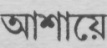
আশায়ে
